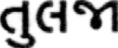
તુલજા
